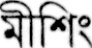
মীশিং
